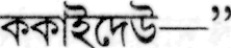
ককাইদেউ-"
